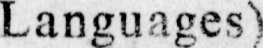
Languages)
